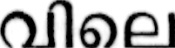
വിലെ
